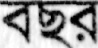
বছর
